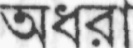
অধরা
